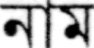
নাম
